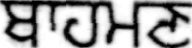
ਬਾਹਮਣ
